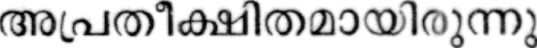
അപ്രതീക്ഷിതമായിരുന്നു
